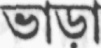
ভাড়া
